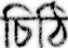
চিঠি
